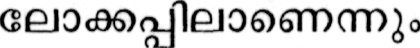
ലോക്കപ്പിലാണെന്നും
